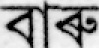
বাৰু
